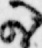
જે
